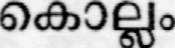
കൊല്ലം
